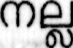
നല്ല
